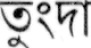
তুংদা
